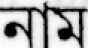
নাম
